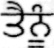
ਤੈਨੂੰ
